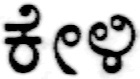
ಕೇಳಿ
